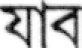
যাব
